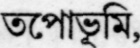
তপোভূমি,
